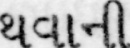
થવાની
